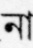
না
